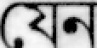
যেন
